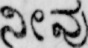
ನೀವು
